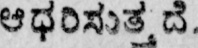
ಆಧರಿಸುತ್ತದೆ.
